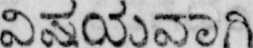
ವಿಷಯವಾಗಿ
